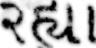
રહ્યા
